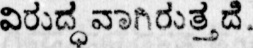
ವಿರುದ್ಧವಾಗಿರುತ್ತದೆ.
